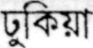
ঢুকিয়া
